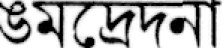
ঙমদ্রেদনা
